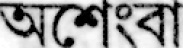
অশেংবা
